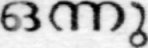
ഒന്നു
